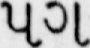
પગ
